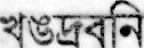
খঙদ্রবনি
